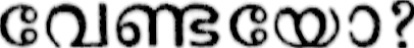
വേണ്ടയോ?
